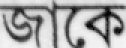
জাকে
